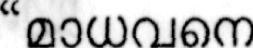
"മാധവനെ
